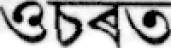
ওচৰত
